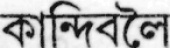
কান্দিবলৈ
